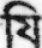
যি
